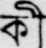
কী
